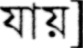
যায়]
